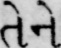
તેને
